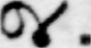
જ.
